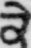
ਕੇ
